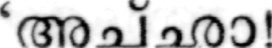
അച് ഛാ!
